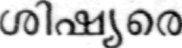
ശിഷ്യരെ
